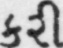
કરી
